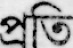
প্রতি
